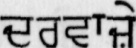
ਦਰਵਾਜ਼ੇ
